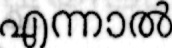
എന്നാല്‍
